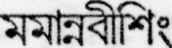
মমান্নবীশিং
